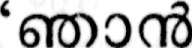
‘ഞാന്‍
